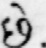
છે.
